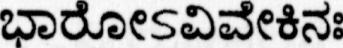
ಭಾರೋsವಿವೇಕಿನಃ
